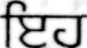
ਇਹ
